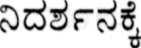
ನಿದರ್ಶನಕ್ಕೆ
